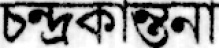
চন্দ্রকান্তনা
